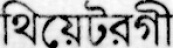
থিয়েটরগী
